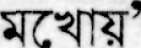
মখোয়’
